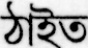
ঠাইত
